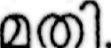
മതി.
